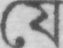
যে
